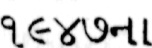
૧૯૪૭ના
